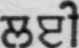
ਲਈ
